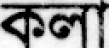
কলা
